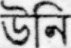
উনি
